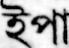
ইপা
